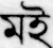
মই
